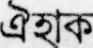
ঐহাক
